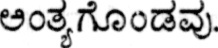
ಅಂತ್ಯಗೊಂಡವು.
